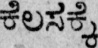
ಕೆಲಸಕ್ಕೆ
